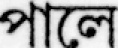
পালে
